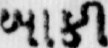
બાકી
